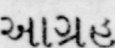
આગ્રહ
